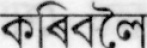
কৰিবলৈ
